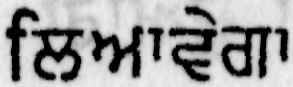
ਲਿਆਵੇਗਾ
